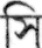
সি
